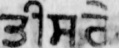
ਤੀਸਰੇ
